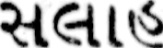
સલાહ
